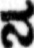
ನ
